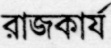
রাজকার্য
